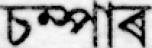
চম্পাৰ
